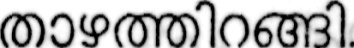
താഴത്തിറങ്ങി.
